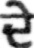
ਦੇ
